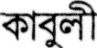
কাবুলী
